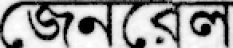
জেনরেল
